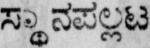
ಸ್ಥಾನಪಲ್ಲಟ
